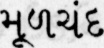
મૂળચંદ
